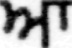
ਆ
